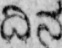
ದಿನ
